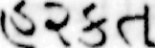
હરકત
